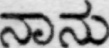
ನಾನು
